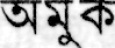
অমুক
